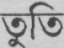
তুতি
